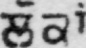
ਲੋਕਾਂ
